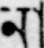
না
